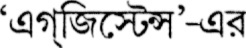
'এগ্‌জিস্টেন্স'-এর
